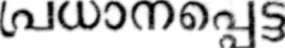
പ്രധാനപ്പെട്ട
